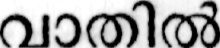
വാതില്‍
